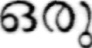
ഒരു
